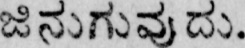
ಜಿನುಗುವುದು.
